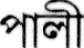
পালী
